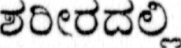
ಶರೀರದಲ್ಲಿ
